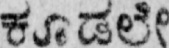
ಕೂಡಲೇ
